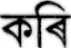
কৰি
